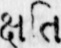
ક્ષતિ
